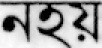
নহয়
